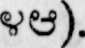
೪ಆ).
